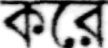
করে
